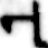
ન
